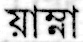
য়াম্না
